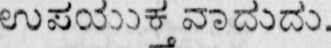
ಉಪಯುಕ್ತವಾದುದು.
